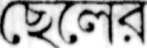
ছেলের
